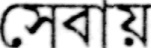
সেবায়
